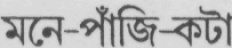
মনে-পাঁজি-কটা
